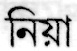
নিয়া
